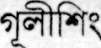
গূলীশিং
